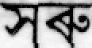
সৰু
